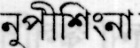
নুপীশিংনা
